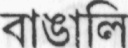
বাঙালি
